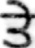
ਤੇ
